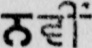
ਨਵੀਂ
